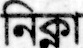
নিক্না
